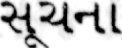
સૂચના
